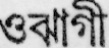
ওঝাগী
